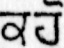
ਕਹੋ
